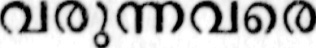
വരുന്നവരെ
